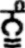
ਨੂੰ
